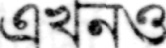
এখনও
